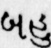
બહુ
